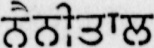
ਨੈਨੀਤਾਲ
